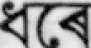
ধৰে
